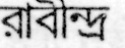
রোবীন্দ্র
